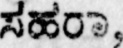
ಸಹರಾ,
